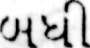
બધી
